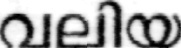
വലിയ
